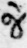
જે
